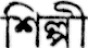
শিল্পী
